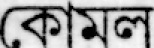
কোমল
